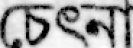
চেৎনা
